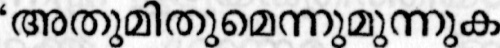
'അതുമിതുമെന്നുമുന്നുക
